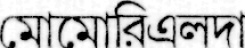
মেমোরিএলদা
